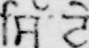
ਸਿੱਟੇ
